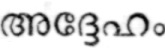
അദ്ദേഹം
